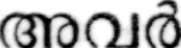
അവര്‍
